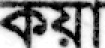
কয়া
